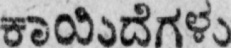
ಕಾಯಿದೆಗಳು
